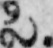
ಪಿ.
